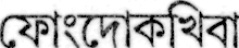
ফোংদোকখিবা
